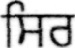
ਸਿਰ
